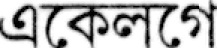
একেলগে
